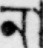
না
